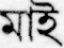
মাই
